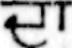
ਦਾ
